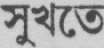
সুখতে
